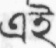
এই
